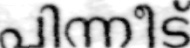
പിന്നീട്
